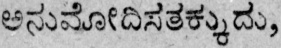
ಅನುಮೋದಿಸತಕ್ಕುದು,
